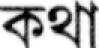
কথা
